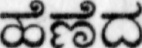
ಹೆಣೆದ
